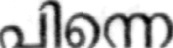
പിന്നെ
